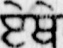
ਏਥੇ
